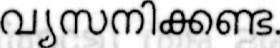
വ്യസനിക്കണ്ട.
